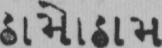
ઠામોઠામ
